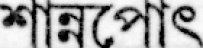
শান্নপোৎ
